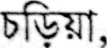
চড়িয়া,
